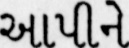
આપીને
